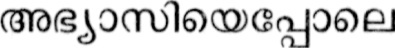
അഭ്യാസിയെപ്പോലെ
